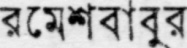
রমেশবাবুর
